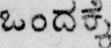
ಒಂದಕ್ಕೆ
